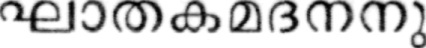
ഘാതകമദനനു
